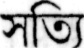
সত্যি
